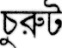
চুরুট
